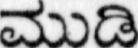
ಮುಡಿ
